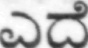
ಎದೆ
